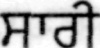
ਸਾਰੀ
